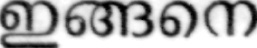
ഇങ്ങനെ
